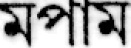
মপাম
